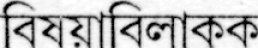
বিষয়াবিলাকক
